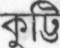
কুট্টি
